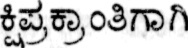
ಕ್ಷಿಪ್ರಕ್ರಾಂತಿಗಾಗಿ
